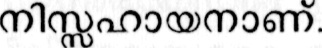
നിസ്സഹായനാണ്.
